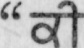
''ਕੀ
